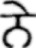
ਨੇ
